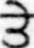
ਤੇ
